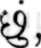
છું,
